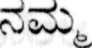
ನಮ್ಮ
